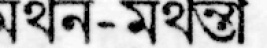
মথন-মথন্তা
